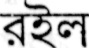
রইল
